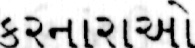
કરનારાઓ
